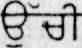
ਉੱਚੀ
